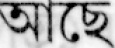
আছে
